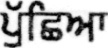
ਪੁੱਛਿਆ
